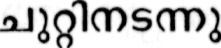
ചുറ്റിനടന്നു
